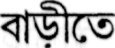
বাড়ীতে
